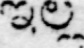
ಇಲ್ಲ
